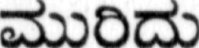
ಮುರಿದು
